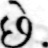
છે.
